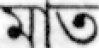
মাত
